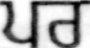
ਪਰ
